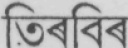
তিৰবিৰ
